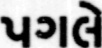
પગલે
